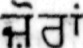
ਜ਼ੋਰਾਂ
